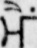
ਮੈਂ
